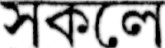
সকলে
